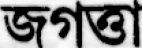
জগত্তা
